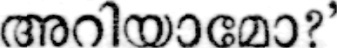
അറിയാമോ?’
